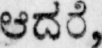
ಆದರೆ,
